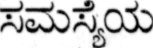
ಸಮಸ್ಯೆಯ
